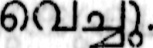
വെച്ചു.
